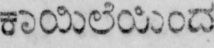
ಕಾಯಿಲೆಯಿಂದ
